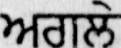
ਅਗਲੇ
